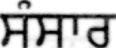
ਸੰਸਾਰ
